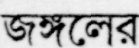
জঙ্গলের
